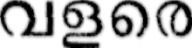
വളരെ
